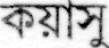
কয়াসু
